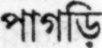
পাগড়ি
